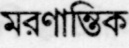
মরণান্তিক
